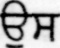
ਉਸ
